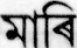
মাৰি
